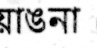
য়াঙনা
